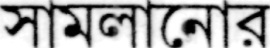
সামলানোর
